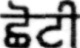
ਛੋਟੀ
